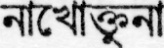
নাখোক্তুনা
